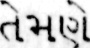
તેમણે
